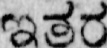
ಇತರ
